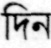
দিন
